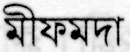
মীফমদা
